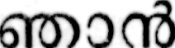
ഞാന്‍
